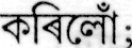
কৰিলোঁ;
